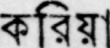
করিয়া
